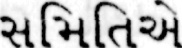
સમિતિએ
